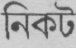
নিকট
